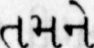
તમને
